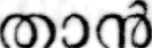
താന്‍
